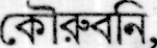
কৌরুবনি,
